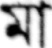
মা
